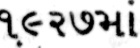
૧૯૨૭માં
